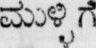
ಮುಳ್ಳಿಗೆ
